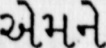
એમને
